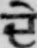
ਦੇ
